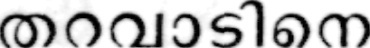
തറവാടിനെ
